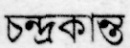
চন্দ্রকান্ত
